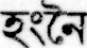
হংনৈ
